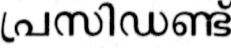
പ്രസിഡണ്ട്
